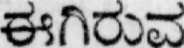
ಈಗಿರುವ
